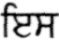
ਇਸ
